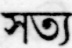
সত্য
